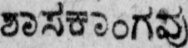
ಶಾಸಕಾಂಗವು
